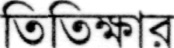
তিতিক্ষার
